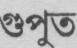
গুপুত
